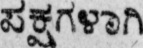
ಪಕ್ಷಗಳಾಗಿ
